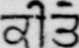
ਕੀਤੇ
